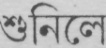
শুনিলে
